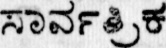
ಸಾರ್ವತ್ರಿಕ
